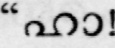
"ഹാ!
